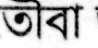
তৌবা
